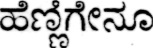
ಹೆಣ್ಣಿಗೇನೂ
